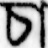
চা
